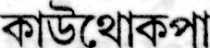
কাউওথোকপা
